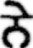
ਨੇ
